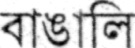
বাঙালি
